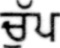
ਚੁੱਪ
